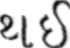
થઈ
